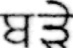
ਬੜੇ
